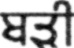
ਬੜੀ
